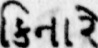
કિનારે
